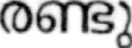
രണ്ടു
